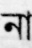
না
